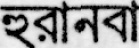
হুরানবা
